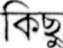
কিছু
